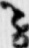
કે
